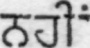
ਨਹੀਂ
